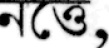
নত্তে,
